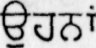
ਉਹਨਾਂ
